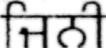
ਜਿਨੀ
